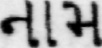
નામ
